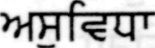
ਅਸੁਵਿਧਾ
